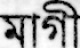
মাগী
